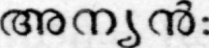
അന്യന്‍:
